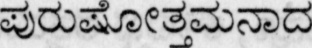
ಪುರುಷೋತ್ತಮನಾದ
